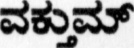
ವಕ್ತುಮ್
